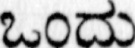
ಒಂದು
